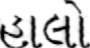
હાલો
